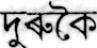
দুৰুকৈ
